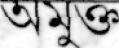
অমুক্ত
